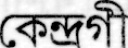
কেন্দ্রগী
